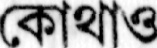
কোথাও
